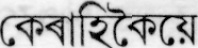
কেৰাহিকৈয়ে
